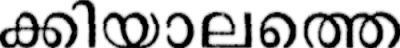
ക്കിയാലത്തെ
